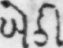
બેઠી
